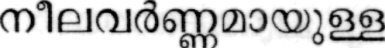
നീലവര്‍ണ്ണമായുള്ള
